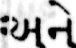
અને
